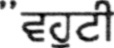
''ਵਹੁਟੀ
